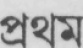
প্ৰথম
